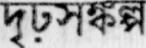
দৃঢ়সঙ্কল্প
